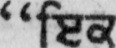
''ਇਕ
